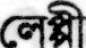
লেপ্পী
